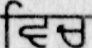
ਵਿਚ
